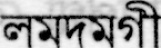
লমদমগী
